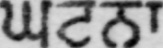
ਘਟਨਾ
